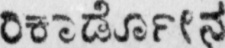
ರಿಕಾರ್ಡೋನ
